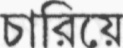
চারিয়ে
